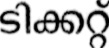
ടിക്കറ്റ്
